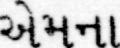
એમના
